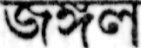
জঙ্গল
